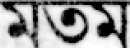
মতম
